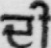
ਦੀ
